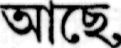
আছে,
